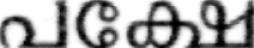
പക്ഷേ
